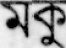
মকু
